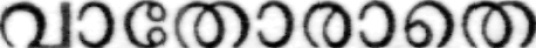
വാതോരാതെ
